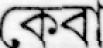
কেবা
